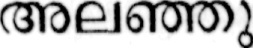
അലഞ്ഞു
